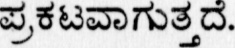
ಪ್ರಕಟವಾಗುತ್ತದೆ.
